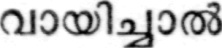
വായിച്ചാല്‍
